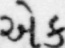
એક
